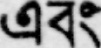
এবং
